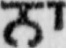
ਨਾ
